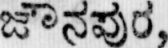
ಜೌನಪುರ,
